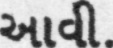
આવી.
